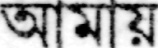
আমায়
